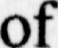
of
